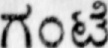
ಗಂಟೆ
